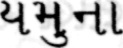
યમુના
